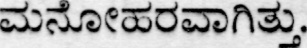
ಮನೋಹರವಾಗಿತ್ತು.
